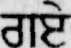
ਗਏ
